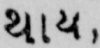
થાય,
